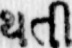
થતી
